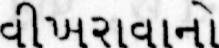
વીખરાવાનો
